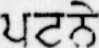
ਪਟਨੇ
